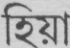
হিয়া
